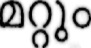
മറ്റും
